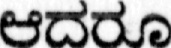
ಆದರೂ
